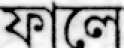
ফালে
